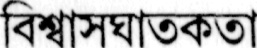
বিশ্বাসঘাতকতা
